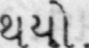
થયો.
